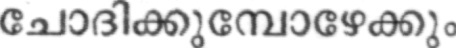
ചോദിക്കുമ്പോഴേക്കും
